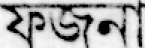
ফজনা
